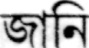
জানি
